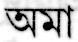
অমা
